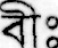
বীঃ
